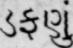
ડફણું
